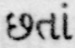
છતાં
